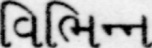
વિભિન્ન
